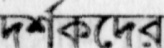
দর্শকদের
